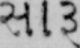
સારૂ
